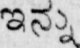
ಇನ್ನು
